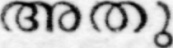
അതു
